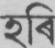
হৰি
